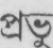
প্ৰভু
